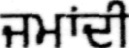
ਜਮਾਂਦੀ
